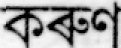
কৰুণ
